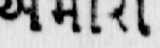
અમારા
